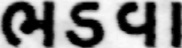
ભડવા
